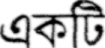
একটি
